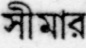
সীমার
